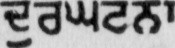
ਦੁਰਘਟਨਾ
